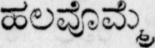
ಹಲವೊಮ್ಮೆ
